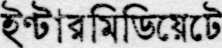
ইন্টারমিডিয়েটে
